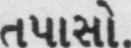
તપાસો.
